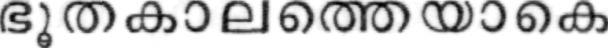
ഭൂതകാലത്തെയാകെ
